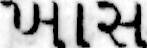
ખાસ
